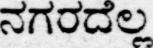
ನಗರದೆಲ್ಲ
